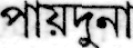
পায়দুনা
